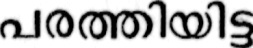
പരത്തിയിട്ട
